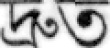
দ্ৰুত
